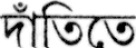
দাঁতিতে
